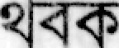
থবক
